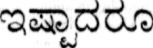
ಇಷ್ಟಾದರೂ
